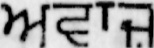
ਅਵਾਜ਼
